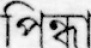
পিন্ধা
